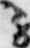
કે
